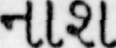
નાશ
